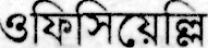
ওফিসিয়েল্লি
